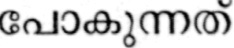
പോകുന്നത്
